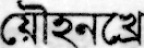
য়ৌহনখ্রে
